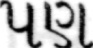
પણ
